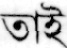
তাই
